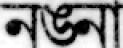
নঙনা
